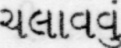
ચલાવવું
